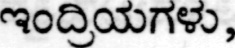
ಇಂದ್ರಿಯಗಳು,
